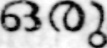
ഒരു
